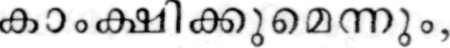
കാംക്ഷിക്കുമെന്നും,
